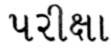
પરીક્ષા
